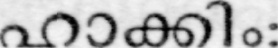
ഹാക്കിം:
